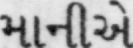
માનીએ
